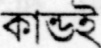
কান্ডই
